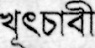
খুৎচাবী
